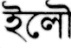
ইলৌ
